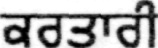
ਕਰਤਾਰੀ
